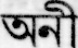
অনী
